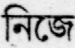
নিজে
